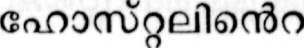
ഹോസ്റ്റലിന്റെ
